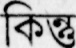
কিন্তু
